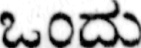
ಒಂದು
